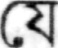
যে
